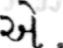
એ.
